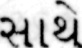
સાથે
